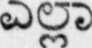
ಎಲ್ಲಾ
